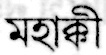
মহাক্কী
